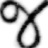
જ
